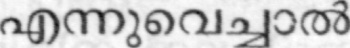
എന്നുവെച്ചാല്‍
